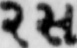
રસ
